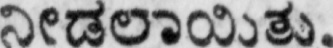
ನೀಡಲಾಯಿತು.
